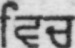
ਵਿਚ
